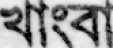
খাংবা
